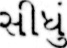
સીધું
